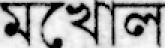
মখোল
